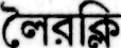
লৈরক্লি
